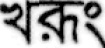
খরূং
